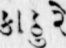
કાઠુરે
